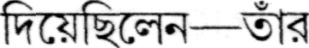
দিয়েছিলেন–তাঁর
